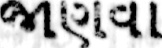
જાણવા
